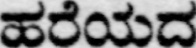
ಹರೆಯದ
